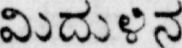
ಮಿದುಳಿನ
